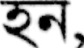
হন,
